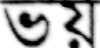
ভয়
